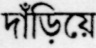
দাঁড়িয়ে
